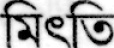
মিৎতি
